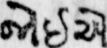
જોઈએ
